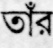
তাঁর
